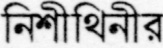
নিশীথিনীর
